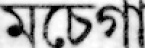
মচেগা
